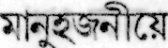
মানুহজনীয়ে
